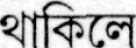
থাকিলে
